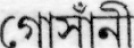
গোসাঁনী
